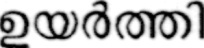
ഉയര്‍ത്തി
